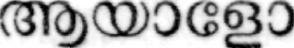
ആയാളോ
